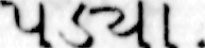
પડ્યા.
